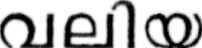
വലിയ
